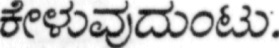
ಕೇಳುವುದುಂಟು.
